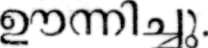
ഊന്നിച്ചു.
